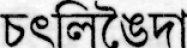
চৎলিঙৈদা
